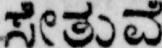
ಸೇತುವೆ
